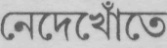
নেদেখোঁতে
